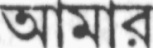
আমার
